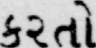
કરતો
